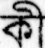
কী
